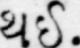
થઈ.
